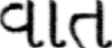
વાત
